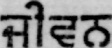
ਜੀਵਨ
